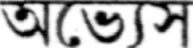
অভ্যেস
